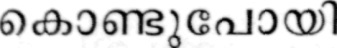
കൊണ്ടുപോയി
